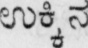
ಉಕ್ಕಿನ
